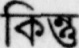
কিন্তু
